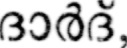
ദാര്‍ദ്,
